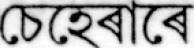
চেহেৰাৰে
